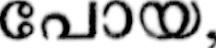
പോയ,
